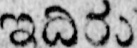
ಇದಿರು
